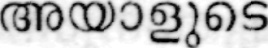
അയാളുടെ
